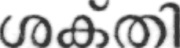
ശക്തി
